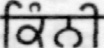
ਕਿੰਨੀ
